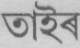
তাইৰ
